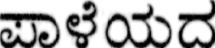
ಪಾಳೆಯದ
